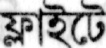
ফ্লাইটে
